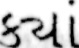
કયાં
